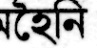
মহৈনি
